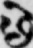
છે
